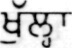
ਖੁੱਲ੍ਹਾ
